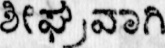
ಶೀಘ್ರವಾಗಿ
